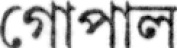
গোপাল
